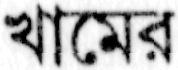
খামের
